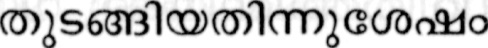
തുടങ്ങിയതിന്നുശേഷം
